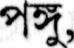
পঙ্গু,
